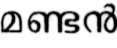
മണ്ടന്‍
